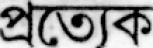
প্ৰত্যেক
